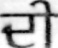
ਦੀ
